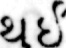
થઈ
